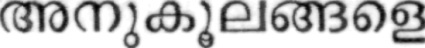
അനുകൂലങ്ങളെ
